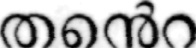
തന്റെ
